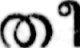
തീ
